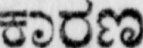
ಕಾರಣ
